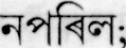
নপৰিল;
